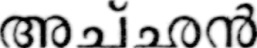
അച്ഛന്‍
